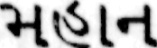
મહાન
